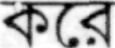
করে
